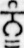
ਨੂੰ
